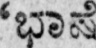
‘ಭಾಷೆ
